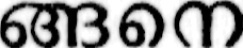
ങ്ങനെ
